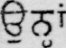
ਉਨ੍ਹਾਂ
